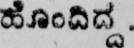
ಹೊಂದಿದ್ದ.
